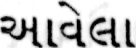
આવેલા
